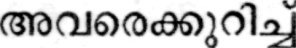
അവരെക്കുറിച്ച്
